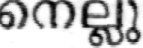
നെല്ലു
